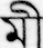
মী
